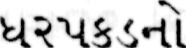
ધરપકડનો
